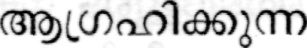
ആഗ്രഹിക്കുന്ന
